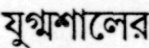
যুগ্মশালের
